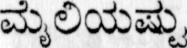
ಮೈಲಿಯಷ್ಟು
